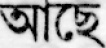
আছে
